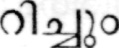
റിച്ചും
